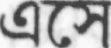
এসে
